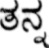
ತನ್ನ
